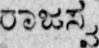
ರಾಜಸ್ವ
